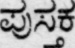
ಪುಸ್ತಕ
